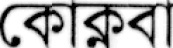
কোক্নবা
